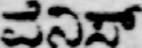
ವೆನಿಸ್
